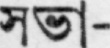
সভা-
